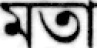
মতা
